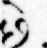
છે.
